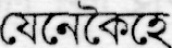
যেনেকৈহে
